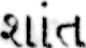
શાંત
